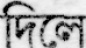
দিলে
